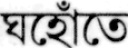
ঘহোঁতে
